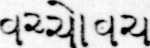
વચ્ચોવચ
